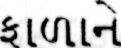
ફાળાને
